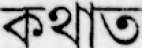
কথাত
